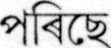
পৰিছে
